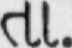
તા.
